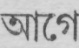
আগে
